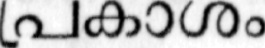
പ്രകാശം
